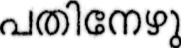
പതിനേഴു
